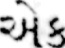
એક
